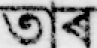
তাৰ
